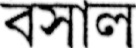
বসাল
